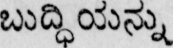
ಬುದ್ಧಿಯನ್ನು
